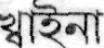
খ্বাইনা
